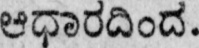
ಆಧಾರದಿಂದ.
